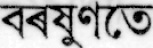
বৰষুণতে
